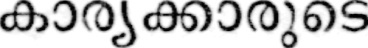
കാര്യക്കാരുടെ
